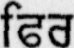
ਫਿਰ
